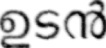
ഉടന്‍
